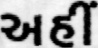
અહીં
